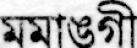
মমাঙগী
